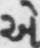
એ
